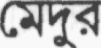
মেদুর
